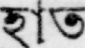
হাত
